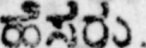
ಹೆಸರು.
